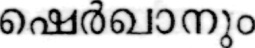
ഷെര്‍ഖാനും
